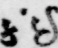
કંઈ
